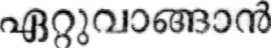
ഏറ്റുവാങ്ങാന്‍
